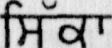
ਸਿੱਕਾ
